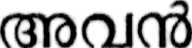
അവന്‍
